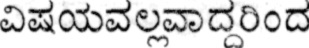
ವಿಷಯವಲ್ಲವಾದ್ದರಿಂದ
